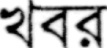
খবর
